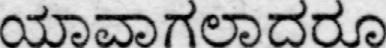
ಯಾವಾಗಲಾದರೂ
